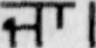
ਜਾ।
